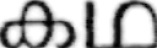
കഥ
